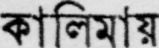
কালিমায়
